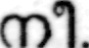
നീ.
